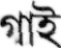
গাই
